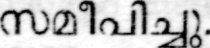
സമീപിച്ചു.
